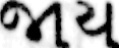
જાય
